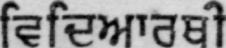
ਵਿਦਿਆਰਥੀ
